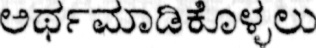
ಅರ್ಥಮಾಡಿಕೊಳ್ಳಲು
